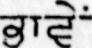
ਭਾਵੇਂ
